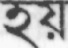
হয়
